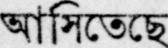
আসিতেছে
